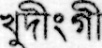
খুদীংগী
